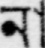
না
